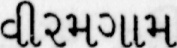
વીરમગામ
